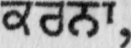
ਕਰਨਾ,
